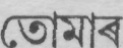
তোমাৰ
